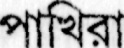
পাখিরা
